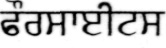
ਫੌਰਸਾਈਟਸ
